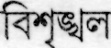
বিশৃঙ্খল
